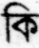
কি
